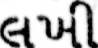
લખી
